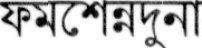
ফমশেন্নদুনা
